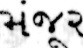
મંજૂર
